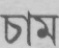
চাম
